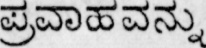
ಪ್ರವಾಹವನ್ನು
